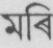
মৰি
